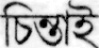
চিন্তাই
